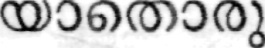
യാതൊരു
